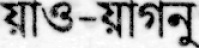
য়াও-য়াগনু
